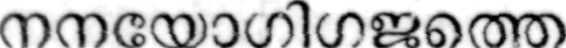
നനയോഗിഗജത്തെ
